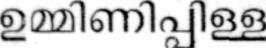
ഉമ്മിണിപ്പിള്ള
